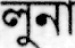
লুনা
